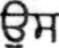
ਉਸ
